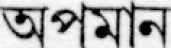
অপমান
